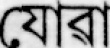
যোৱা
